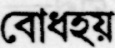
বোধহয়
